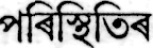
পৰিস্হিতিৰ
